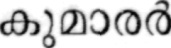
കുമാരര്‍
